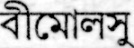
বীমোলসু
